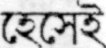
হেসেই
